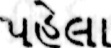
પહેલા
